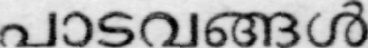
പാടവങ്ങള്‍
